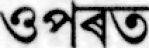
ওপৰত
